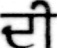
ਦੀ
